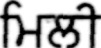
ਮਿਲੀ
